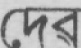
দেৱ
